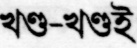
খণ্ড-খণ্ডই
